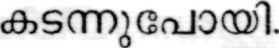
കടന്നുപോയി.
